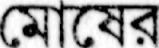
মোষের
